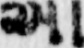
આ
